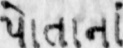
પોતાનાં
